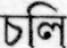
চলি
